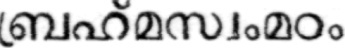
ബ്രഹ്മസ്വംമഠം
